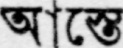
আস্তে
